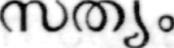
സത്യം
